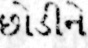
છોડીને
